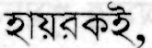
হায়রকই,
